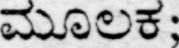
ಮೂಲಕ;
